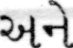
અને
